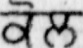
ਕੋਲ
